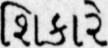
શિકારે
